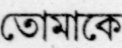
তোমাকে
